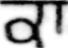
ਕਾ
